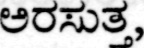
ಅರಸುತ್ತ,
